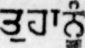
ਤੁਹਾਨੂੰ
